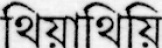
থিয়াথিয়ি
